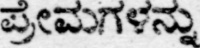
ಪ್ರೇಮಗಳನ್ನು
